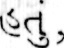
હતું,
